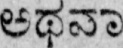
ಅಥವಾ
